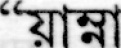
“য়াম্না
